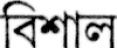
বিশাল
